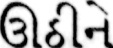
ઊઠીને
